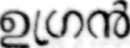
ഉഗ്രന്‍
